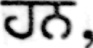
ਹਨ,
